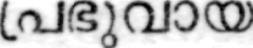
പ്രഭുവായ
